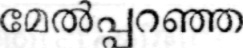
മേല്‍പ്പറഞ്ഞ
